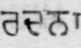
ਰਚਨਾ
